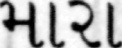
મારા
